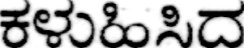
ಕಳುಹಿಸಿದ
